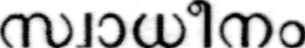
സ്വാധീനം
